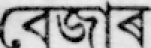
বেজাৰ
